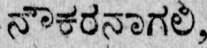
ನೌಕರನಾಗಲಿ,
